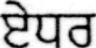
ਏਧਰ
